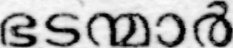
ഭടന്മാര്‍
